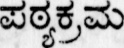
ಪಠ್ಯಕ್ರಮ
